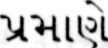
પ્રમાણે
